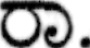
ರಾ.
